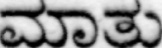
ಮಾತು
